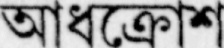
আধক্রোশ
